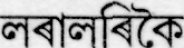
লৰালৰিকৈ
